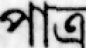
পাত্র
